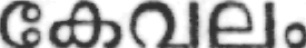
കേവലം
